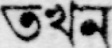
তখন
